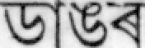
ডাঙৰ
